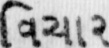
વિચાર
